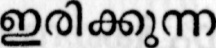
ഇരിക്കുന്ന
